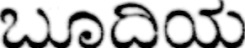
ಬೂದಿಯ
